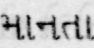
માનતા
